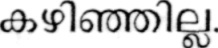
കഴിഞ്ഞില്ല.
